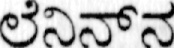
ಲೆನಿನ್‌ನ
